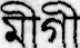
মীগী
